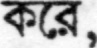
করে,
